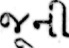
જૂની
